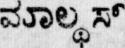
ಮಾಲ್ಥಸ್
